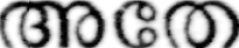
അതേ
